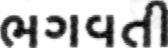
ભગવતી
